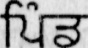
ਪਿੰਡ
